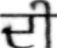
ਦੀ
